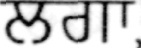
ਲਗਾ,
